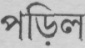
পড়িল
